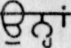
ਉਨ੍ਹਾਂ
